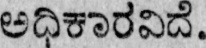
ಅಧಿಕಾರವಿದೆ.
